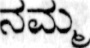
ನಮ್ಮ
